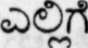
ಎಲ್ಲಿಗೆ
